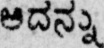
ಅದನ್ನು
